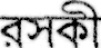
রসকী
